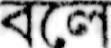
বলে
